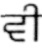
ਵੀ
